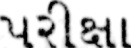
પરીક્ષા
